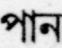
পান
